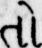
તો
